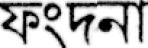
ফংদনা
